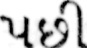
પછી
